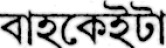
বাহকেইটা
